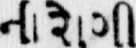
નીરોગી
